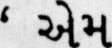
'એમ
